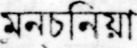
মন্‌চনিয়া
